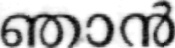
ഞാന്‍
